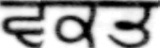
ਵਕਤ
